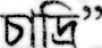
চাদ্রি”
